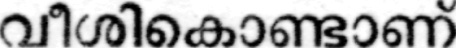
വീശികൊണ്ടാണ്
